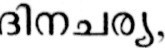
ദിനചര്യ,
